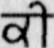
ਕੀ
